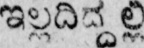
ಇಲ್ಲದಿದ್ದಲ್ಲಿ
